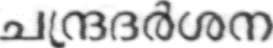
ചന്ദ്രദര്‍ശന
